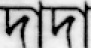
দাদা
